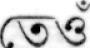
তেওঁ
